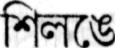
শিলঙে
